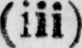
(iii)
